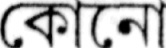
কোনো
